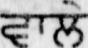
ਵਾਲੇ
